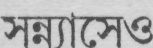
সন্ন্যাসেও
